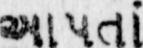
આપતાં
